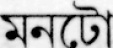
মনটো
